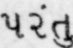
પરંતુ
